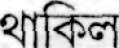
থাকিল
